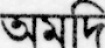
অমদি
